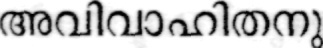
അവിവാഹിതനു
